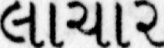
લાચાર
